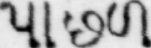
પાછળ
